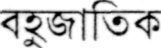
বহুজাতিক
